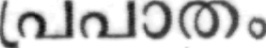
പ്രപാതം
